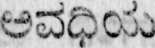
ಅವಧಿಯ
